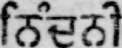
ਨਿੰਦਨੀ
